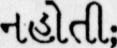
નહોતી;
